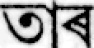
তাৰ
